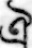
ঐ
